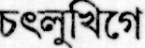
চৎলুখিগে
